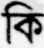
কি
